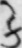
કે
